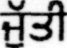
ਜੁੱਤੀ
